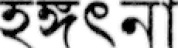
হঙ্গৎনা
